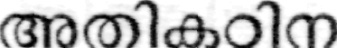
അതികഠിന
